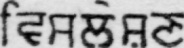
ਵਿਸਲੇਸ਼ਣ
